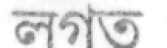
লগত
